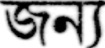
জন্য
